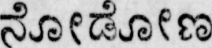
ನೋಡೋಣ
